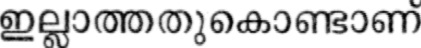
ഇല്ലാത്തതുകൊണ്ടാണ്
